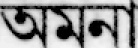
অমনা
